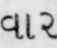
વાર
